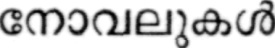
നോവലുകള്‍
